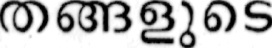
തങ്ങളുടെ
